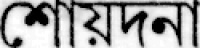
শোয়দনা
